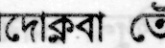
দোক্নবা তৌ
